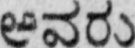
ಅವರು
